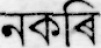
নকৰি
